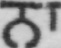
ਨਾ
